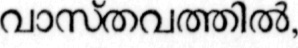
വാസ്തവത്തില്‍,
